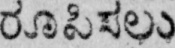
ರೂಪಿಸಲು
